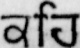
ਕਹਿ
